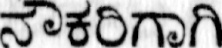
ನೌಕರಿಗಾಗಿ
